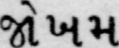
જોખમ
